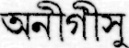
অনীগীসু
